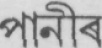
পানীৰ
